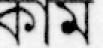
কাম
